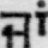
ਜਾਂ
